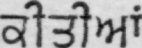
ਕੀਤੀਆਂ
